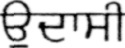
ਉਦਾਸੀ
